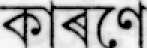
কাৰণে
